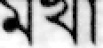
মখা
